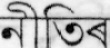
নীতিৰ
